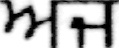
ਅਜ
